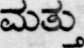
ಮತ್ತು
